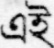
এই
